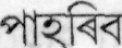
পাহৰিব
